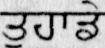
ਤੁਹਾਡੇ
